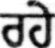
ਰਹੇ
